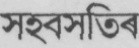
সহবসতিৰ
